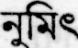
নুমিৎ
